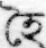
হৈ
